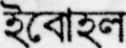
ইবোহল
